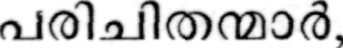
പരിചിതന്മാര്‍,
